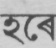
হৰে
